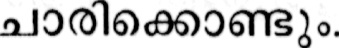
ചാരിക്കൊണ്ടും.
